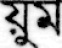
য়ুম
